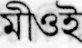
মীওই
